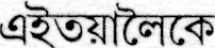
এইতয়ালৈকে
